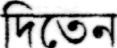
দিতেন
